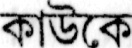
কাউকে
